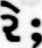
રે;
